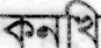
কনখি
